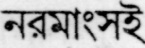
নরমাংসই
